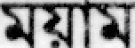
ময়াম
